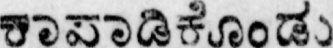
ಕಾಪಾಡಿಕೊಂಡು
